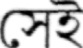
সেই
